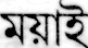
ময়াই
